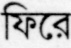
ফিরে
